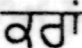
ਕਰਾਂ
